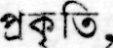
প্রকৃতি,
